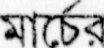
মার্চের
